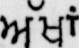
ਅੱਖਾਂ
